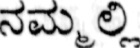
ನಮ್ಮಲ್ಲಿ
